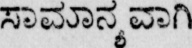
ಸಾಮಾನ್ಯವಾಗಿ
